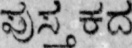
ಪುಸ್ತಕದ
